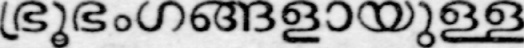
ഭ്രൂഭംഗങ്ങളായുള്ള
